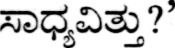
ಸಾಧ್ಯವಿತ್ತು?'
